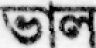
ভাল
